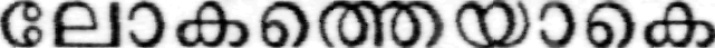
ലോകത്തെയാകെ
